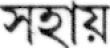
সহায়
